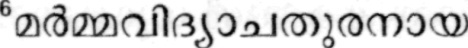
6മര്‍മ്മവിദ്യാചതുരനായ
